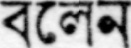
বলেন
